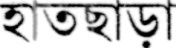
হাতছাড়া
